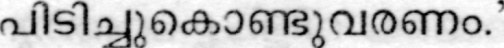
പിടിച്ചുകൊണ്ടുവരണം.’
